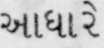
આધારે
